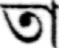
তা
